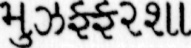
મુઝફ્ફરશા
